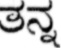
ತನ್ನ
